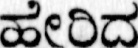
ಹೇರಿದ
